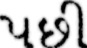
પછી
